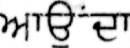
ਆਉਂਦਾ
